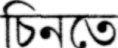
চিনতে
